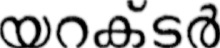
യറക്ടര്‍
